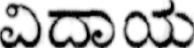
ವಿದಾಯ
